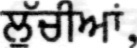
ਲੁੱਚੀਆਂ,
